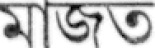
মাজত
